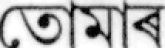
তোমাৰ
